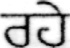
ਰਹੇ
